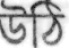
উঠি
